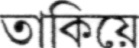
তাকিয়ে
